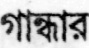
গান্ধার
